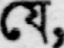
যে,
